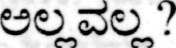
ಅಲ್ಲವಲ್ಲ?
